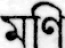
মণি
